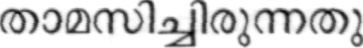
താമസിച്ചിരുന്നതു
